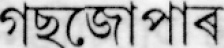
গছজোপাৰ
